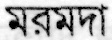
মরমদা
